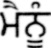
ਮੈਨੂੰ
